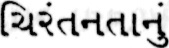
ચિરંતનતાનું
